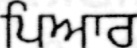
ਪਿਆਰ
